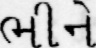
ભીને
